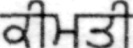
ਕੀਮਤੀ
